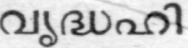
വൃദ്ധഹി
